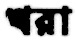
খরা
